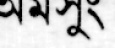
অমসুং
